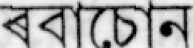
ৰবাচোন
